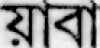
য়াবা
